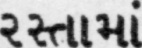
રસ્તામાં
